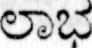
ಲಾಭ
